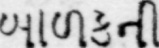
બાળકની
